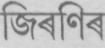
জিৰণিৰ
